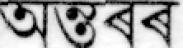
অন্তৰৰ
